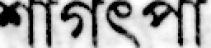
শাগৎপা
